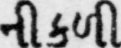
નીકળી
